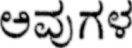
ಅವುಗಳ
